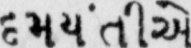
દમયંતીએ
